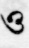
ও
